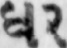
ઘર
